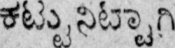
ಕಟ್ಟುನಿಟ್ಟಾಗಿ
